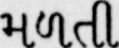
મળતી
